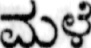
ಮಳೆ
